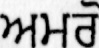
ਅਮਰੋ
